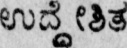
ಉದ್ದೇಶಿತ
